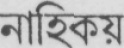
নাহিকয়
